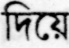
দিয়ে
